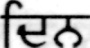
ਦਿਨ
